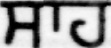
ਸਾਹ
